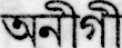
অনীগী
